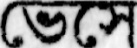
ভেসে
